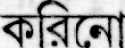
করিনো
